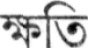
ক্ষতি
